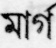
মার্গ
